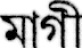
মাগী
